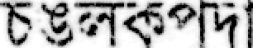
চঙলকপদা
